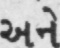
અને
